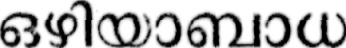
ഒഴിയാബാധ
